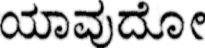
ಯಾವುದೋ
